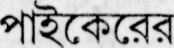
পাইকেরের
